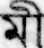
মী
